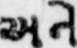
અને
